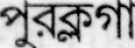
পুরক্লগা
